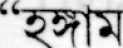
“হঙ্গাম
